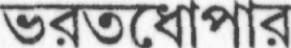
ভরতধোপার
